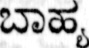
ಬಾಹ್ಯ
